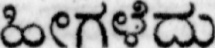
ಹೀಗಳೆದು
